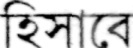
হিসাবে
